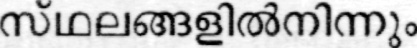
സ്ഥലങ്ങളില്‍നിന്നും
